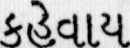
કહેવાય
